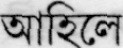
আহিলে
